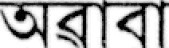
অৱাবা
